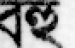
বহু
